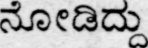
ನೋಡಿದ್ದು
